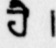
ਹੈ।
